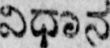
ವಿಧಾನ
